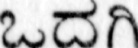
ಒದಗಿ
